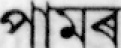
পামৰ
